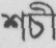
শচী
